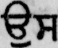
ਉਸ
